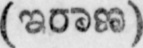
(ಇರಾಣ)
